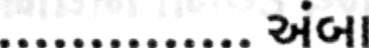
..........અંબા
